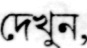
দেখুন,
